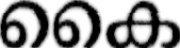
കൈ
